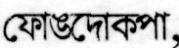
ফোঙদোকপা,
